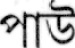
পাউ
